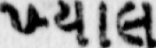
ખ્યાલ
